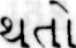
થતો
